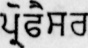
ਪ੍ਰੋਫੈਸਰ
